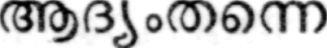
ആദ്യംതന്നെ
